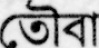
তৌবা
